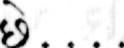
છે....
